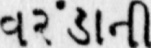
વરંડાની
